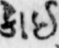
કોઈ
